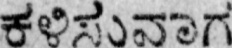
ಕಳಿಸುವಾಗ
